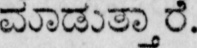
ಮಾಡುತ್ತಾರೆ.
